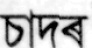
চাদৰ
